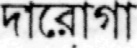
দারোগা
